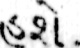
હશે.
